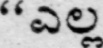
“ಎಲ್ಲ
